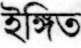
ইঙ্গিত
